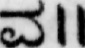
ವ||
